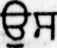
ਉਸ
